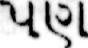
પણ
